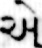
એ
